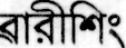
ৱারীশিং
